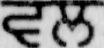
ਵਲ
